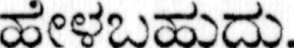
ಹೇಳಬಹುದು.
